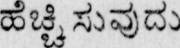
ಹೆಚ್ಚಿಸುವುದು
